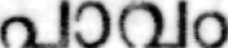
പാവം
